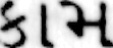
કામ
